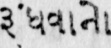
રૂંધવાનો
